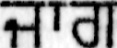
ਜਾਗ
